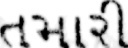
તમારી
